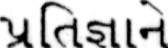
પ્રતિજ્ઞાને
